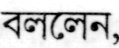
বললেন,
